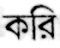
করি
